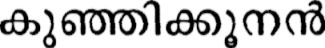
കുഞ്ഞിക്കൂനന്‍
